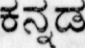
ಕನ್ನಡ
